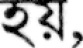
হয়,
